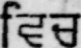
ਵਿਚ
